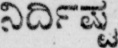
ನಿರ್ದಿಷ್ಟ
